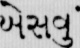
બેસવું
